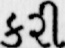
કરી
